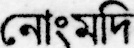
নোংমদি
